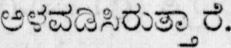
ಅಳವಡಿಸಿರುತ್ತಾರೆ.
